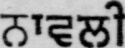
ਨਾਵਲੀ
